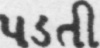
પડતી
